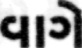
વાગે
